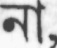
না,
